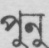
পুনু
